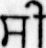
ਸੀ
